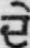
ਦੇ
